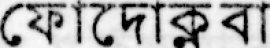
ফোদোক্নবা
